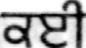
ਕਈ
